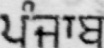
ਪੰਜਾਬ
